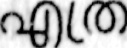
എത്ര
